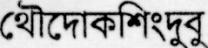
থৌদোকশিংদুবু
